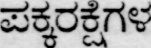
ಪಕ್ಕರಕ್ಷೆಗಳ
